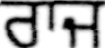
ਰਾਜ
